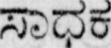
ಸಾಧಕ
